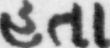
હતા
